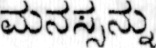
ಮನಸ್ಸನ್ನು
